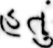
હતું
